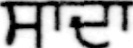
ਸਾਦਾ
